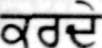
ਕਰਦੇ
